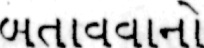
બતાવવાનો
